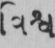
વિશ્વ
